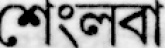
শেংলবা
